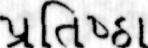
પ્રતિષ્ઠા
